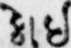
કોઈ
